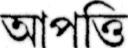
আপত্তি
